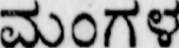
ಮಂಗಳ
